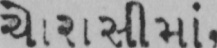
ચોરાસીમાં
